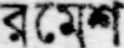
রমেশ
